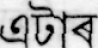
এটাৰ
